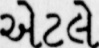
એટલે
